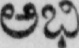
ಅಭಿ
